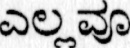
ಎಲ್ಲವೂ
